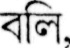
বলি,
